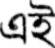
এই
